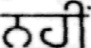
ਨਹੀਂ
